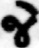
જે
